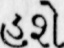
હશે
